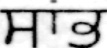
ਸਾਂਭ
